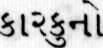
કારકુનો
